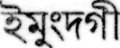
ইমুংদগী
